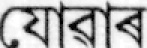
যোৱাৰ
